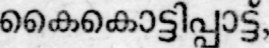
കൈകൊട്ടിപ്പാട്ട്,
